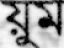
য়ুম
